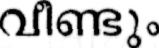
വീണ്ടും
